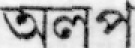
অলপ
